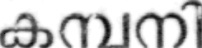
കമ്പനി
